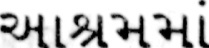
આશ્રમમાં
